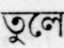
তুলে
